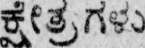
ಕ್ಷೇತ್ರಗಳು
